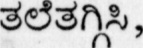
ತಲೆತಗ್ಗಿಸಿ,
